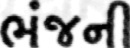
ભંજની
